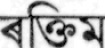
ৰক্তিম
